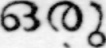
ഒരു
